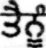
ਤੈਨੂੰ
